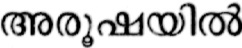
അരൂഷയില്‍
